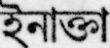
ইনাক্তা
